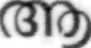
ആ
